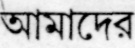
আমাদের
